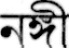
নঙ্গী
